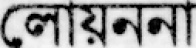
লোয়ননা
